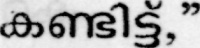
കണ്ടിട്ട്,"
